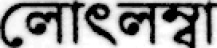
লোৎলম্বা
